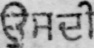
ਉਸਦੀ
